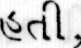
હતી,
